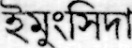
ইমুংসিদা
